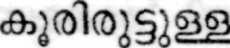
കൂരിരുട്ടുള്ള
